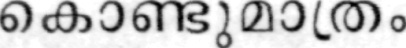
കൊണ്ടുമാത്രം
